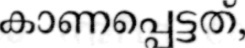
കാണപ്പെട്ടത്,
